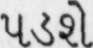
પડશે
